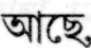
আছে,
